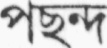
পছন্দ
